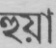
হুয়া
